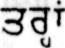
ਤਰ੍ਹਾਂ
